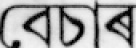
বেচাৰ
